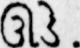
ઊડે.
